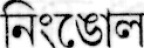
নিংঙোল
